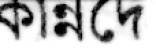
কান্নদে
